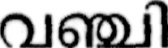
വഞ്ചി
